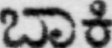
ಬಾಕಿ
